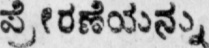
ಪ್ರೇರಣೆಯನ್ನು
